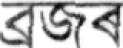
ব্রজৰ
